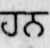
ਹਨ
